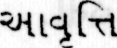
આવૃત્તિ
